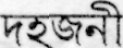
দহজনী
